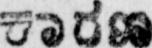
ಕಾರಣ
